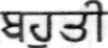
ਬਹੁਤੀ
